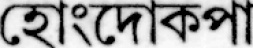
হোংদোকপা
